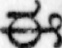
ಈ
